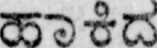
ಹಾಕಿದ
